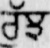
ਰੁੱਝ
